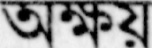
অক্ষয়
